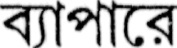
ব্যাপারে
